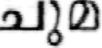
ചുമ
